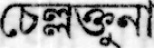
চেল্লক্তুনা
